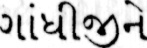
ગાંધીજીને
